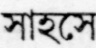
সাহসে
